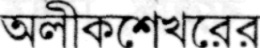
অলীকশেখরের
